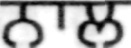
ਨਾਲ
